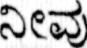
ನೀವು
